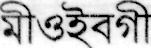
মীওইবগী
